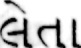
લેતા
